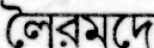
লৈরমদে
